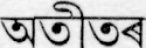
অতীতৰ
